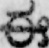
ಈ
